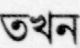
তখন
